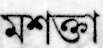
মশক্তা
